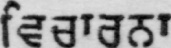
ਵਿਚਾਰਨਾ
